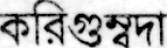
করিগুম্বদা
